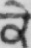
ਕੇ
